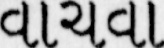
વાચવા
